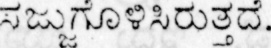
ಸಜ್ಜುಗೊಳಿಸಿರುತ್ತದೆ.
